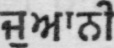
ਜੁਆਨੀ
